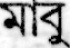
মাবু
